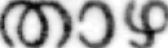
താഴ
